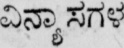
ವಿನ್ಯಾಸಗಳ
